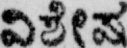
ವಿಶೇಷ
